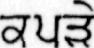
ਕਪੜੇ
